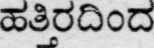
ಹತ್ತಿರದಿಂದ
